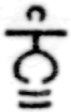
ਨੂੰ
